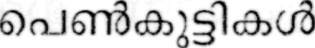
പെണ്‍കുട്ടികള്‍
